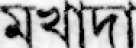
মখাদা
